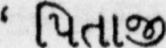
'પિતાજી
